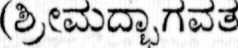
(ಶ್ರೀಮದ್ಭಾಗವತ
